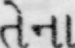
તેના
